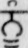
ਨੂੰ
